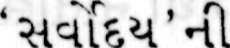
'સર્વોદય'ની
